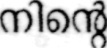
നിന്റെ
